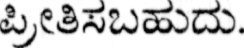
ಪ್ರೀತಿಸಬಹುದು.
